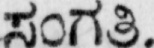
ಸಂಗತಿ.
